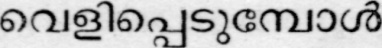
വെളിപ്പെടുമ്പോള്‍
